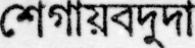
শেগায়বদুদা
